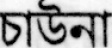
চাউনা
